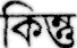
কিন্তু
